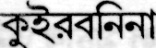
কুইরবনিনা
